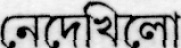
নেদেখিলো
